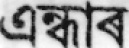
এন্ধাৰ
